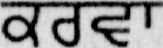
ਕਰਵਾ
